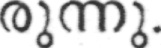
രുന്നു.
